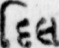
દિલ
